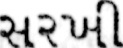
સરખી
